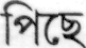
পিছে
